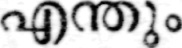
എന്തും
